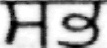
ਸਭ
